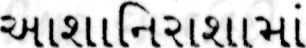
આશાનિરાશામાં
